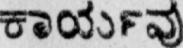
ಕಾರ್ಯವು
